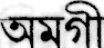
অমগী
